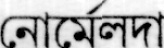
নোর্মেলদা
